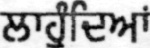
ਲਾਹੁੰਦਿਆਂ
